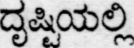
ದೃಷ್ಟಿಯಲ್ಲಿ
